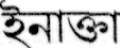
ইনাক্তা
